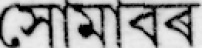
সোমাবৰ
